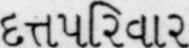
દત્તપરિવાર
